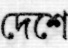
দেশে
